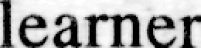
learner
